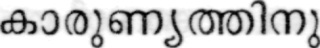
കാരുണ്യത്തിനു
